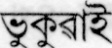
ভুকুৱাই
